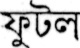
ফুটল
